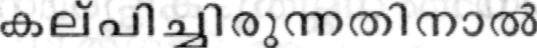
കല്പിച്ചിരുന്നതിനാല്‍
